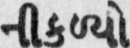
નીકળ્યો
